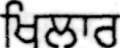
ਖਿਲਾਰ
